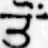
ਤੋਂ
